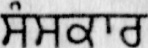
ਸੰਸਕਾਰ
